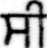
ਸੀ
